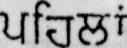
ਪਹਿਲਾਂ
